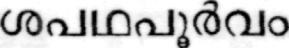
ശപഥപൂര്‍വം
